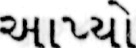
આપ્યો
